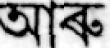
আৰু
